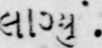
લાગ્યું.
